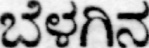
ಬೆಳಗಿನ
